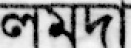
লমদা
